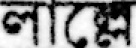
লাল্লে
